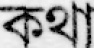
কথা
